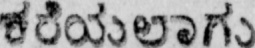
ಕರೆಯಲಾಗು
